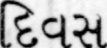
દિવસ
